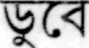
ডুবে
